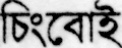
চিংবোই
